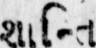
શાન્તિ
